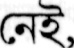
নেই,
